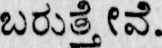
ಬರುತ್ತೇವೆ.
